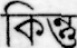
কিন্তু
